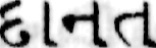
દાનત
